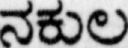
ನಕುಲ
